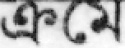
ক্ৰমে
